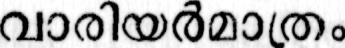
വാരിയര്‍മാത്രം
